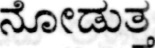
ನೋಡುತ್ತ
